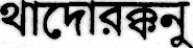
থাদোরক্কনু
